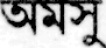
অমসু
